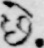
છે.
